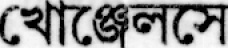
খোঞ্জেলসে
